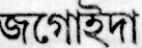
জগোইদা
